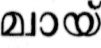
മ്വായ്
